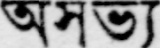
অসভ্য
